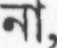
না,
